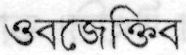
ওবজেক্তিব
